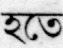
হতে
